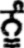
ਨੂੰ
